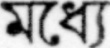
মধ্যে
